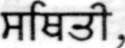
ਸਥਿਤੀ,
